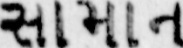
સામાન
